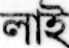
লাই
